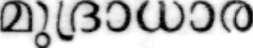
മുദ്രാധാര
